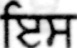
ਇਸ
